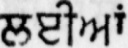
ਲਈਆਂ
